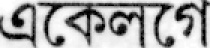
একেলগে
